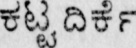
ಕಟ್ಟದಿರ್ಕೆ
